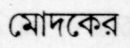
মোদকের
